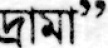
দ্রামা”
